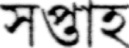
সপ্তাহ
